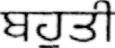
ਬਹੁਤੀ
